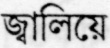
জ্বালিয়ে
